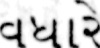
વધારે
